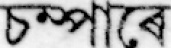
চম্পাৰে
